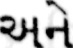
અને
